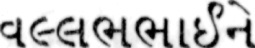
વલ્લભભાઈને
